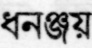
ধনঞ্জয়
